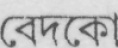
বেদকো
